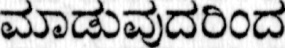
ಮಾಡುವುದರಿಂದ
